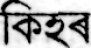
কিহৰ
